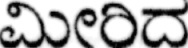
ಮೀರಿದ
